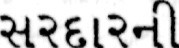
સરદારની
